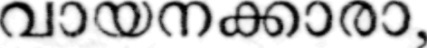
വായനക്കാരാ,
